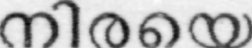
നിരയെ
